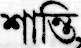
শান্তি,
